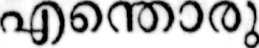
എന്തൊരു
